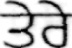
ਤੇਰੇ
